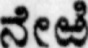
ನೇಱ
